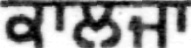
ਕਾਲਜਾ
